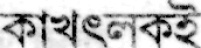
কাখৎলকই
